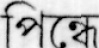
পিন্ধে
